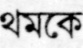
থমকে
